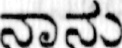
ನಾನು
